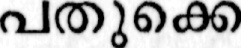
പതുക്കെ
